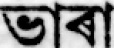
ভাৰা
